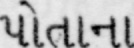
પોતાના
